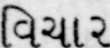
વિચાર
